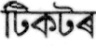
টিকটৰ
